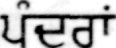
ਪੰਦਰਾਂ
